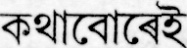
কথাবোৰেই
